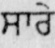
ਸਾਰੇ
